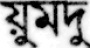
য়ুমদু
